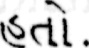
હતો.
